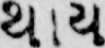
થાય
